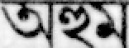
অহুম
